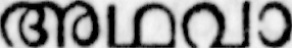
അഥവാ
